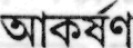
আকৰ্ষণ
